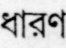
ধারণ
